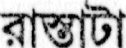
রাস্তাটা
